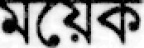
ময়েক
